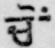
ਚੋਂ
